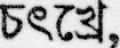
চৎখ্রে,
